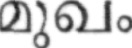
മുഖം
